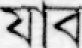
যাব
